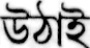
উঠাই
